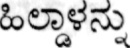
ಹಿಲ್ಡಾಳನ್ನು
